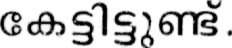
കേട്ടിട്ടുണ്ട്.
